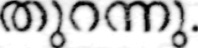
തുറന്നു.
